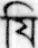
যি
